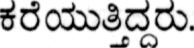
ಕರೆಯುತ್ತಿದ್ದರು.
